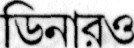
ডিনারও
